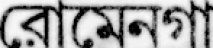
রোমেনগা
